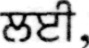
ਲਈ,
